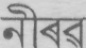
নীৰৱ
